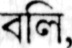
বলি,
